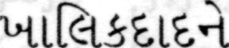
ખાલિકદાદને
